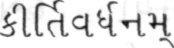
કીર્તિવર્ધનમ્
